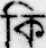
কি
